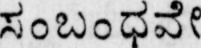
ಸಂಬಂಧವೇ
